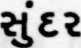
સુંદર
